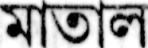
মাতাল
